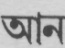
আন
